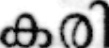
കരി
